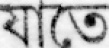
যাতে
